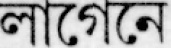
লাগেনে
